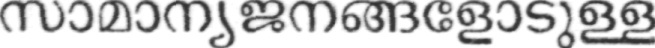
സാമാന്യജനങ്ങളോടുള്ള
